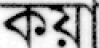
কয়া
